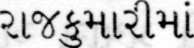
રાજકુમારીમાં
